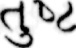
તુષ્ટ
